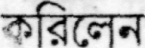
করিলেন
